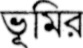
ভূমির
